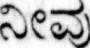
ನೀವು
